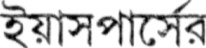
ইয়াসপার্সের
